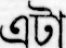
এটা
